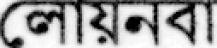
লোয়নবা
